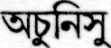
অচুনিসু
